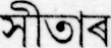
সীতাৰ
